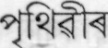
পৃথিৱীৰ
